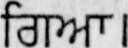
ਗਿਆ।
